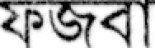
ফজবা
